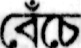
বেঁচে
